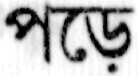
পড়ে
